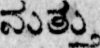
ಮತ್ತು
